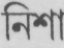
নিশা
